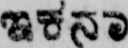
ಇಕನಾ
